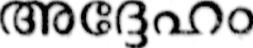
അദ്ദേഹം
